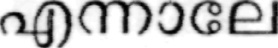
എന്നാലേ
